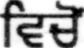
ਵਿਚੋਂ
